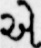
એ
